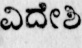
ವಿದೇಶಿ
